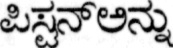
ಪಿಸ್ಟನ್‌ಅನ್ನು
